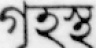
গৃহস্হ
